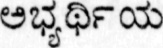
ಅಭ್ಯರ್ಥಿಯ
